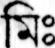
মিঃ
